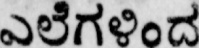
ಎಲೆಗಳಿಂದ
